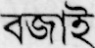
বজাই
